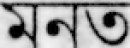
মনত
